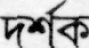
দর্শক
